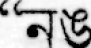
“নঙ
